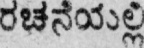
ರಚನೆಯಲ್ಲಿ
